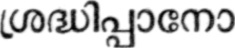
ശ്രദ്ധിപ്പാനോ
